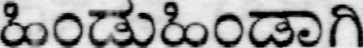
ಹಿಂಡುಹಿಂಡಾಗಿಯ
